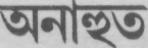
অনাহুত
